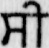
ਸੀ
